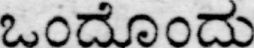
ಒಂದೊಂದು
